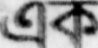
এক
